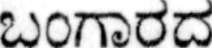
ಬಂಗಾರದ
